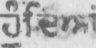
ਹੁੰਦਿਆਂ
